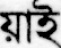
য়াই
